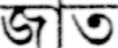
জাত
